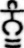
ਨੂੰ
